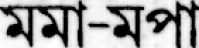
মমা-মপা
